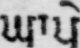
ਘਾਪੇ
